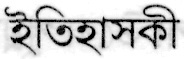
ইতিহাসকী
